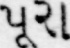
પૂરો
